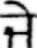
ਜੇ
